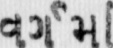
વર્ગમાં
